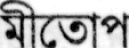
মীতোপ
